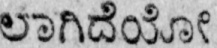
ಲಾಗಿದೆಯೋ
